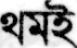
থমই
